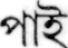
পাই
